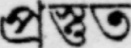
প্রস্তুত
